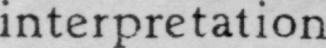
interpretation
